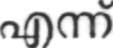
എന്ന്
